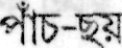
পাঁচ-ছয়
